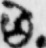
છે.
